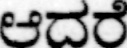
ಆದರೆ
